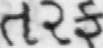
તરફ
